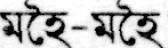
মহৈ-মহৈ
